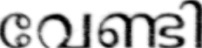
വേണ്ടി
